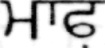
ਮਾਫ਼
